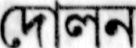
দোলন
